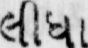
લીધા
